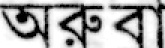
অরুবা
